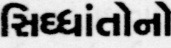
સિધ્ધાંતોનો
